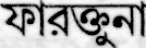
ফারক্তুনা
